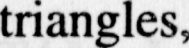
triangles,
